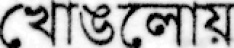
খোঙলোয়
